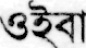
ওইবা
